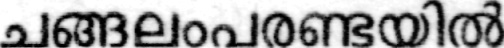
ചങ്ങലംപരണ്ടയില്‍
